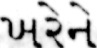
ખરેને
